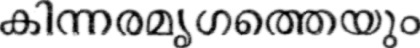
കിന്നരമൃഗത്തെയും
